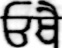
ਓਥੈ
